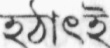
হঠাৎই
